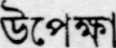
উপেক্ষা
